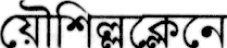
য়ৌশিল্লক্লেনে
